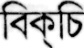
বিক্‌চি
